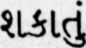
શકાતું
